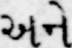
અને
